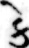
કે
